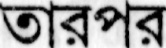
তারপর
